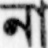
না
